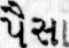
પૈસા
